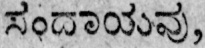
ಸಂದಾಯವು,
